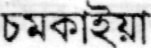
চমকাইয়া
